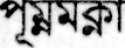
পূম্নমক্না
